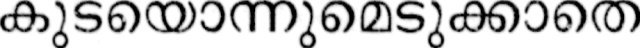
കുടയൊന്നുമെടുക്കാതെ
